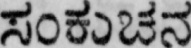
ಸಂಕುಚನ
